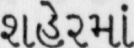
શહેરમાં
